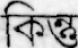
কিন্তু
